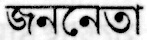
জননেতা
